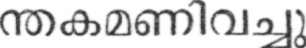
ന്തകമണിവച്ചു
